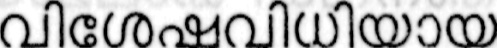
വിശേഷവിധിയായ
